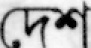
দেশ
